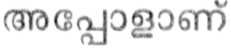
അപ്പോളാണ്
